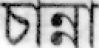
চান্না
